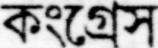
কংগ্রেস
